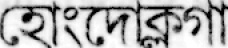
হোংদোক্লগা
